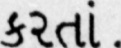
કરતાં.
